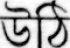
উঠি
